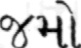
જમો
